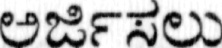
ಅರ್ಜಿಸಲು
